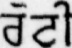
ਰੋਟੀ
